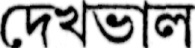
দেখভাল
